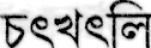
চৎখৎলি
